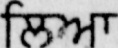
ਲਿਆ
